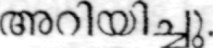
അറിയിച്ചു.
